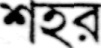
শহর
